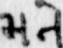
મને
